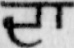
ਦਾ
